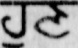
ਹੁਣ
